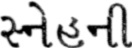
સ્નેહની
